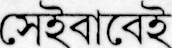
সেইবাবেই
